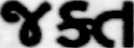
જક્ત
